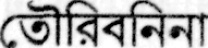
তৌরিবনিনা
